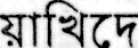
য়াখিদে
